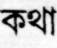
কথা
